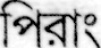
পিরাং
